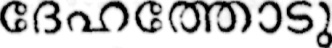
ദേഹത്തോടു
